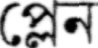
প্লেন
